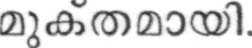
മുക്തമായി.
